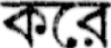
করে
